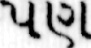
પણ
